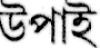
উপাই
